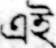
এই
